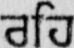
ਰਹਿ
